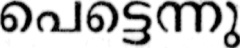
പെട്ടെന്നു
